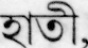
হাতী,
